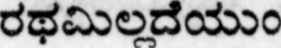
ರಥಮಿಲ್ಲದೆಯುಂ
